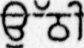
ਉੱਠੀ
